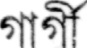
গার্গী
